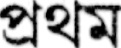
প্রথম
